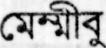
মেম্মীবু
